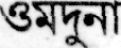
ওমদুনা
